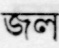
জল
